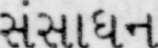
સંસાધન
